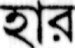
হার
